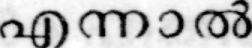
എന്നാല്‍
